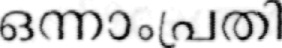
ഒന്നാംപ്രതി
